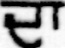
ਦਾ
